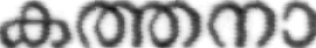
കത്തനാ
